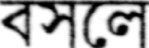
বসলে
